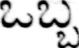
ಒಬ್ಬ
